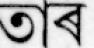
তাৰ
